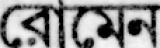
রোমেন
